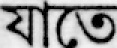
যাতে
